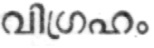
വിഗ്രഹം
